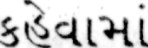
કહેવામાં
